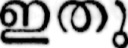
ഇതു
